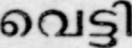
വെട്ടി
